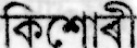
কিশোৰী
